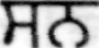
ਸਨ
